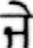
ਜੇ
